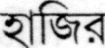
হাজির
